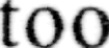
too
